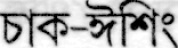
চাক-ঈশিং
